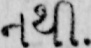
નથી.
